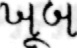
ખૂબ
